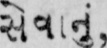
સેવાનું,
